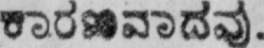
ಕಾರಣವಾದವು.
